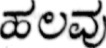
ಹಲವು
